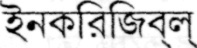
ইনকরিজিব্‌ল্
